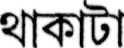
থাকাটা
